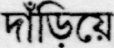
দাঁড়িয়ে
